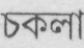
চকলা
